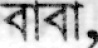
বাবা,
